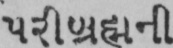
પરીબ્રહ્મની
